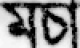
মচা
